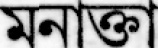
মনাক্তা
